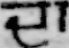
ਦਾ
